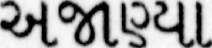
અજાણ્યા
